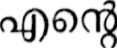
എന്റെ
